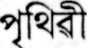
পৃথিৱী
